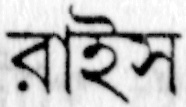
রাইস
